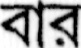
বার
